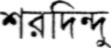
শরদিন্দু
